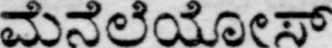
ಮೆನೆಲೆಯೋಸ್
